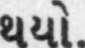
થયો.
